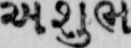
અશુભ
